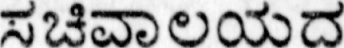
ಸಚಿವಾಲಯದ
